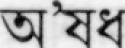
অ'ষধ
